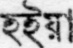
হইয়া
